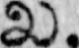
ಖ.
